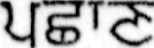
ਪਛਾਣ
